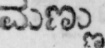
ಮಣ್ಣು
